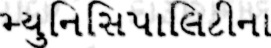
મ્યુનિસિપાલિટીના
